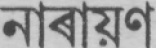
নাৰায়ণ
